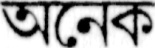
অনেক
